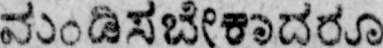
ಮಂಡಿಸಬೇಕಾದರೂ
